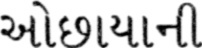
ઓછાયાની
